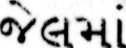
જેલમાં
